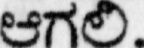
ಆಗಲಿ.
